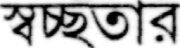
স্বচ্ছতার
